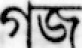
গজ
